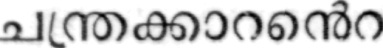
ചന്ത്രക്കാറന്റെ
